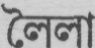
লৈলা
